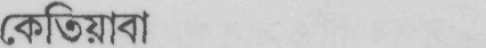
কেতিয়াবা
